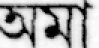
অমা
